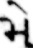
મે
